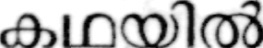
കഥയില്‍
